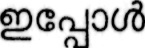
ഇപ്പോള്‍
